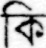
কি
